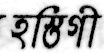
হস্তিগী
